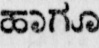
ಹಾಗೂ
